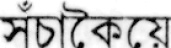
সঁচাকৈয়ে
